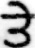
ਤੇ
